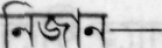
নিজান-
